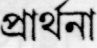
প্রার্থনা
